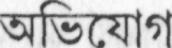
অভিযোগ
